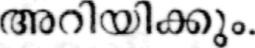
അറിയിക്കും.
